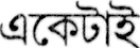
একেটাই
